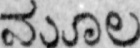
ಮೂಲ
